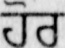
ਹੋਰ
